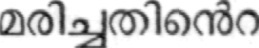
മരിച്ചതിന്റെ
